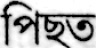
পিছত
